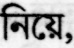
নিয়ে,
